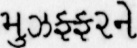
મુઝફ્ફરને
